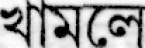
খামলে
